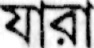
যারা
